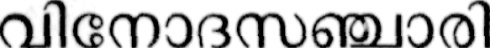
വിനോദസഞ്ചാരി
